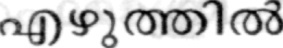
എഴുത്തില്‍
